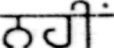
ਨਹੀਂ
